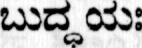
ಬುದ್ಧಯಃ
